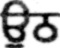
ਉਠ
